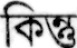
কিন্তু
